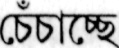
চেঁচাচ্ছে
